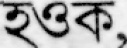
হওক,
